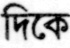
দিকে
